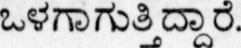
ಒಳಗಾಗುತ್ತಿದ್ದಾರೆ.
